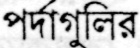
পর্দাগুলির
